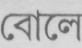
বোলে
